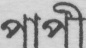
পাপী
